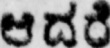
ಆದರೆ
